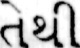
તેથી
